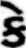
કે
